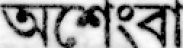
অশেংবা
